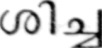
ശിച്ച
